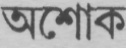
অশোক
